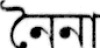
নৈনা
